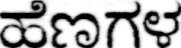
ಹೆಣಗಳ
